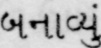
બનાવ્યું
